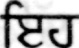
ਇਹ
